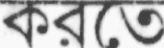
করতে
